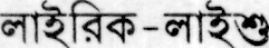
লাইরিগক-লাইশু
